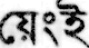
য়েংই
